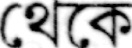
থেকে
